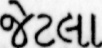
જેટલા
